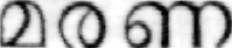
മരണ
